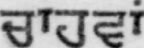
ਚਾਹਵਾਂ
